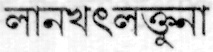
লানখৎলক্তুনা
